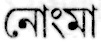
নোংমা
